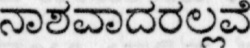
ನಾಶವಾದರಲ್ಲವೆ
